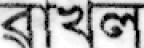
ৱাখল
